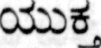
ಯುಕ್ತ
